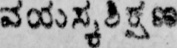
ವಯಸ್ಕಶಿಕ್ಷಣ
